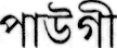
পাউগী
